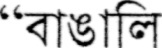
“বাঙালি
